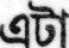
এটা
